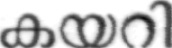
കയറി
